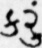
કરું
